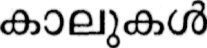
കാലുകള്‍
